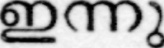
ഇന്നു
